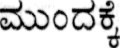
ಮುಂದಕ್ಕೆ
